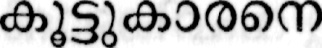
കൂട്ടുകാരനെ
